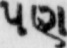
પણ
